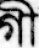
গী
